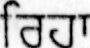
ਰਿਹਾ
